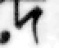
দে
